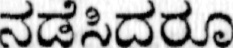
ನಡೆಸಿದರೂ
